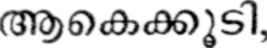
ആകെക്കൂടി,
